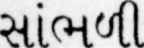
સાંભળી
